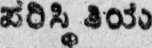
ಪರಿಸ್ಥಿತಿಯ
